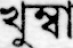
খুম্বা
